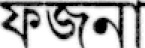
ফজনা
